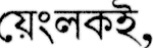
য়েংলকই,
